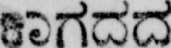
ಕಾಗದದ
